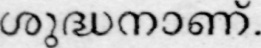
ശുദ്ധനാണ്.
